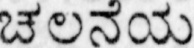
ಚಲನೆಯ
